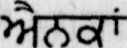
ਐਨਕਾਂ
